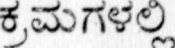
ಕ್ರಮಗಳಲ್ಲಿ
